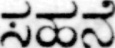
ಸಹನೆ
